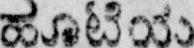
ಹೂಟೆಯ
